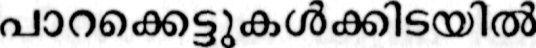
പാറക്കെട്ടുകള്‍ക്കിടയില്‍
